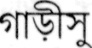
গাড়ীসু
